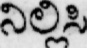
ನಿಲ್ಲಿಸಿ
